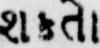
શકતો
